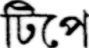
টিপে
